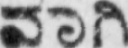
ವಾಗಿ
